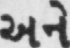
અને
